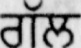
ਗੱਲ
